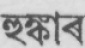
হুঙ্কাৰ
